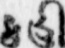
કહી
